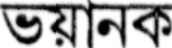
ভয়ানক
